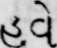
હવે
